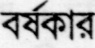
বর্ষকার
